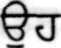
ਉਹ
